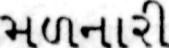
મળનારી
